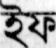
ইফ
